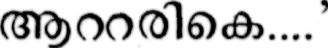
ആററരികെ....’
